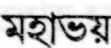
মহাভয়
